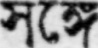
সঙ্গে
